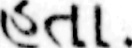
હતા.
